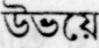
উভয়ে
